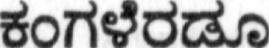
ಕಂಗಳೆರಡೂ
